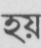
হয়
